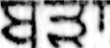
ਬੜਾ
